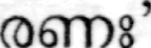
രണഃ'
